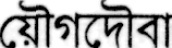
য়ৌগদবা
